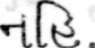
નહિ.
